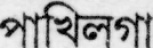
পাখিলগা
